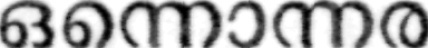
ഒന്നൊന്നര
